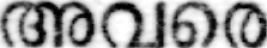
അവരെ
